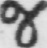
જ
